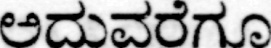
ಅದುವರೆಗೂ
